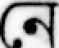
নে
